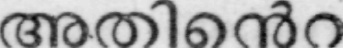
അതിന്റെ
